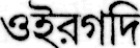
ওইরগদি
